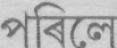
পৰিলে
